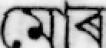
মোৰ
